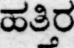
ಹತ್ತಿರ
